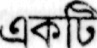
একটি
